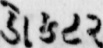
ડોક્ટર
